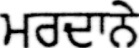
ਮਰਦਾਨੇ
